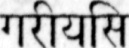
गर्रायसि
